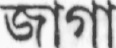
জাগা
